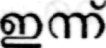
ഇന്ന്
